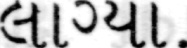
લાગ્યા.
